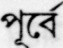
পূর্বে
